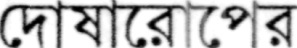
দোষারোপের
